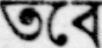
তবে
